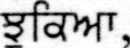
ਝੁਕਿਆ,
